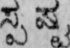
ಸ್ಪಷ್ಟ
